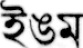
ইঙম
